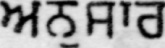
ਅਨੁਸਾਰ
